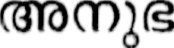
അനുഭ
